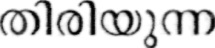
തിരിയുന്ന
